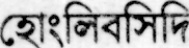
হোংলিবসিদি
